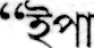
“ইপা
